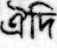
ঐদি
